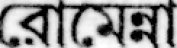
রোমেন্না
